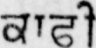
ਕਾਫੀ
